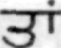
ਤਾਂ
